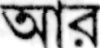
আর
